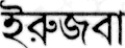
ইরুজবা
